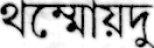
থম্মোয়দু
